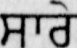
ਸਾਰੇ
